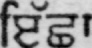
ਇੱਛਾ
